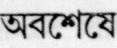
অবশেষে
